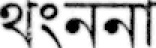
থংনবা
